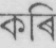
কৰি
